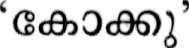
‘കോക്കു'
